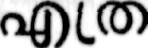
എത്ര
